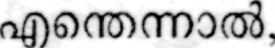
എന്തെന്നാല്‍,
